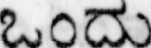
ಒಂದು
